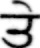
ਤੇ
